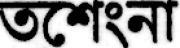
তশেংনা
